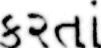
કરતાં
